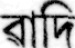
ৱাদি
